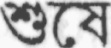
শুষে
